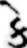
કે
